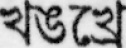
খঙখ্রে
